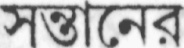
সন্তানের
